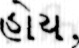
હોય,
